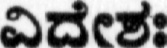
ವಿದೇಶಃ
